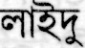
লাইদু
